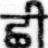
ਛੀ
